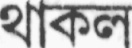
থাকল
